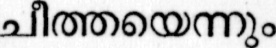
ചീത്തയെന്നും
